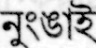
নুংঙাই
